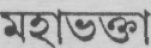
মহাভক্তা
